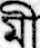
মী
